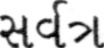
સર્વત્ર
